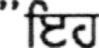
''ਇਹ
